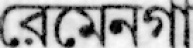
রোমেনগা
